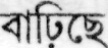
বাঢ়িছে
